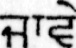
ਜਾਵੇ
